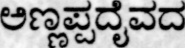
ಅಣ್ಣಪ್ಪದೈವದ
